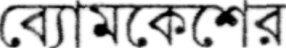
ব্যোমকেশের
